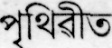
পৃথিৱীত
